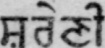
ਸ਼ਰੇਣੀ
